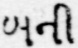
બની
